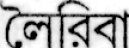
লৈরিবা
